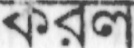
করল
